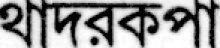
থাদরকপা
